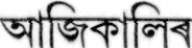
আজিকালিৰ
